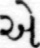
એ
